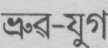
ভ্ৰুৱ-যুগ
